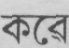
কৱে
